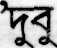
’দুবু
